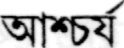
আশ্চর্য
